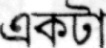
একটা
